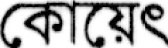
কোয়েৎ
